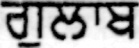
ਗੁਲਾਬ
